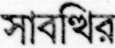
সাবত্থির
